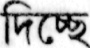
দিচ্ছে
